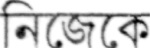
নিজেকে
